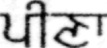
ਪੀਣਾ
